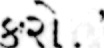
કરો.'
